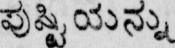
ಪುಷ್ಟಿಯನ್ನು
